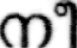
നീ
